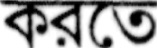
করতে
